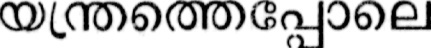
യന്ത്രത്തെപ്പോലെ
